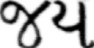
જય
